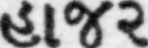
હાજર
